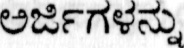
ಅರ್ಜಿಗಳನ್ನು
